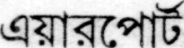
এয়ারপোর্ট
